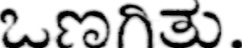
ಒಣಗಿತು.
